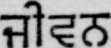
ਜੀਵਨ
